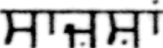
ਸਾਜ਼ਸ਼ਾਂ
